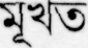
মূখত
